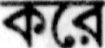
করে
